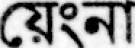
য়েংনা
